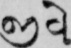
જીવે
